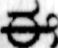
ಈ
